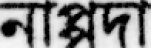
নাপ্পদা
